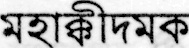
মহাক্কীদমক
